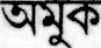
অমুক
